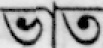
ভাত
